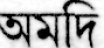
অমদি
